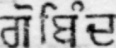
ਗੋਬਿੰਦ
